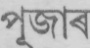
পূজাৰ
